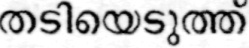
തടിയെടുത്ത്
